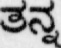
ತನ್ನ
